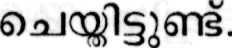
ചെയ്തിട്ടുണ്ട്.
